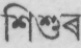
শিশুৰ
